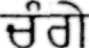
ਚੰਗੇ
